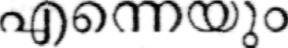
എന്നെയും
